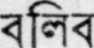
বলিব
